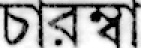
চারম্বা
